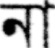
না
